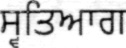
ਸ੍ਵਤਿਆਗ
